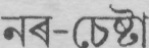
নৰ-চেষ্টা
